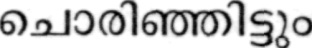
ചൊരിഞ്ഞിട്ടും
